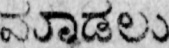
ಮಾಡಲು
